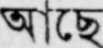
আছে
